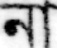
না
